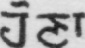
ਹੋਣਾ
